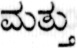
ಮತ್ತು
